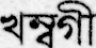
খম্বগী
